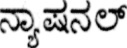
ನ್ಯಾಷನಲ್
